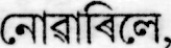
নোৱাৰিলে,
